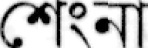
শেংনা
